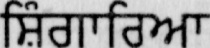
ਸ਼ਿੰਗਾਰਿਆ
